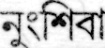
নুংশিবা
